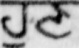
ਹੁਣ
